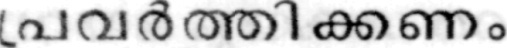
പ്രവര്‍ത്തിക്കണം
